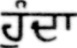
ਹੁੰਦਾ
